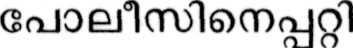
പോലീസിനെപ്പറ്റി
